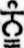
ਨੂੰ
